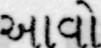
આવો
